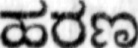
ಹರಣ
